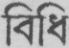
বিধি
